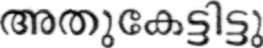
അതുകേട്ടിട്ടു
